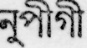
নুপীগী
